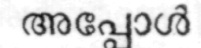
അപ്പോള്‍
